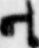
ન
